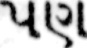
પણ
